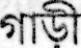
গাড়ী
